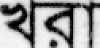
খরা
